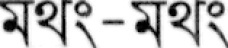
মথং-মথং
